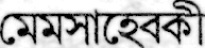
মেমসাহেবকী
